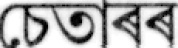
চেতাৰৰ
